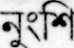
নুংশি
